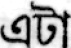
এটা
